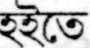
হইতে
